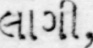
લાગી,
